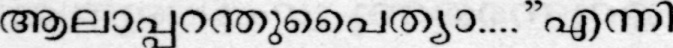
ആലാപ്പറന്തുപൈത്യാ....''’എന്നി
